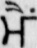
ਮੈਂ
